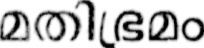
മതിഭ്രമം
